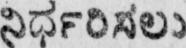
ನಿರ್ಧರಿಸಲು
